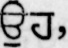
ਉਹ,
